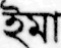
ইমা
